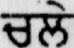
ਚਲੇ
